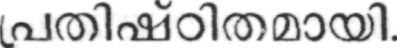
പ്രതിഷ്ഠിതമായി.
